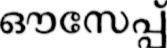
ഔസേപ്പ്
